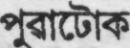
পুৱাটোক
